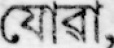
যোৱা,
